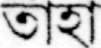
তাহা
